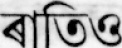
ৰাতিও
